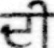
ਦੀ
